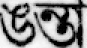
ঙন্তা
